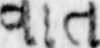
વાત
